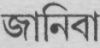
জানিবা
